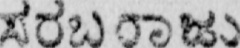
ಸರಬರಾಜು
